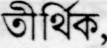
তীর্থিক,
